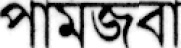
পামজবা
